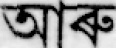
আৰু
